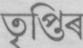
তৃপ্তিৰ
